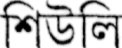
শিউলি
